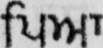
ਪਿਆ
